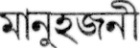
মানুহজনী
